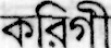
করিগী
